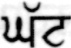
ਘੱਟ
